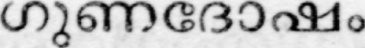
ഗുണദോഷം
